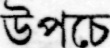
উপচে
